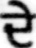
ਦੇ
